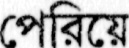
পেরিয়ে
